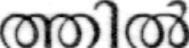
ത്തില്‍
